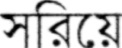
সরিয়ে
